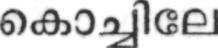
കൊച്ചിലേ
